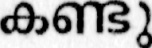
കണ്ടു
